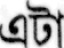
এটা
